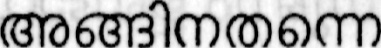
അങ്ങിനതന്നെ
